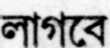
লাগবে
